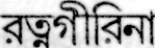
রত্নগীরিনা
